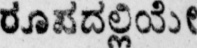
ರೂಪದಲ್ಲಿಯೇ
